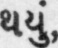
થયું,
